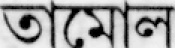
তামোল
